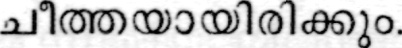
ചീത്തയായിരിക്കും.
